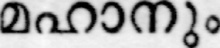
മഹാനും
